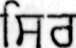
ਸਿਰ
